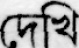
দেখি
